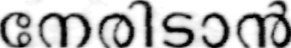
നേരിടാന്‍
